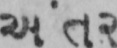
અંતર
